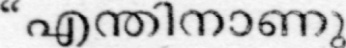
"എന്തിനാണു
